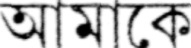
আমাকে
